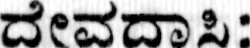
ದೇವದಾಸಿ:
